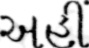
અહીં
